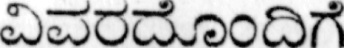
ವಿವರದೊಂದಿಗೆ
